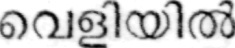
വെളിയില്‍
